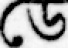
ডে
